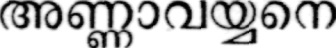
അണ്ണാവയ്യനെ
